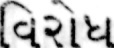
વિરોધ
